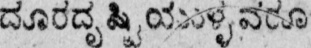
ದೂರದೃಷ್ಟಿಯುಳ್ಳವರೂ
